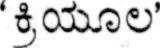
'ಕ್ರಿಯೂಲ'
